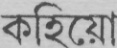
কহিয়ো
